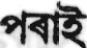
পৰাই
